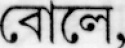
বোলে,
